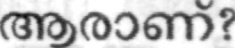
ആരാണ്?
